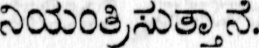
ನಿಯಂತ್ರಿಸುತ್ತಾನೆ.
